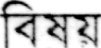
বিষয়
